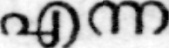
എന്ന
